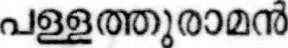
പള്ളത്തുരാമന്‍
